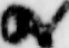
જ
